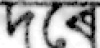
দৰে
